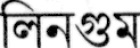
লিনগুম
